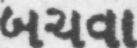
બચવા
